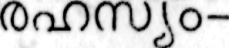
രഹസ്യം-
